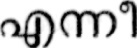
എന്നീ
